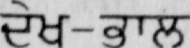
ਦੇਖ-ਭਾਲ
